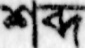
শব্দ
